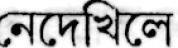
নেদেখিলে
